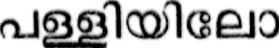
പള്ളിയിലോ
